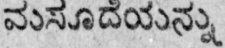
ಮಸೂದೆಯನ್ನು
